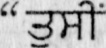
''ਤੁਸੀਂ
